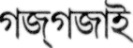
গজ্‌গজাই
